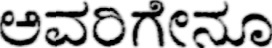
ಅವರಿಗೇನೂ
